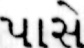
પાસે
